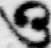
ও
